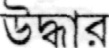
উদ্ধার
